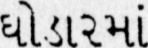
ઘોડારમાં
